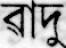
ৱাদু
